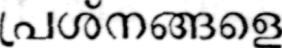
പ്രശ്നങ്ങളെ
